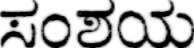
ಸಂಶಯ
